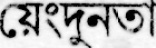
য়েংদুনতা
